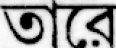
তারে
